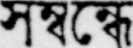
সম্বন্ধে
